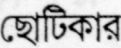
ছোটিকার
